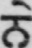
ਨੇ
